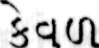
કેવળ
